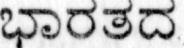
ಭಾರತದ
